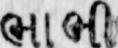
ભાભી
